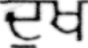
ਦੁਖ
